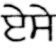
ਏਸੇ
